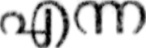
എന്ന
